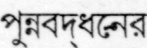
পুন্নবদ্ধনের
